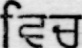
ਵਿਚ
